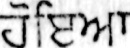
ਹੋਇਆ
